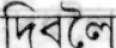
দিবলৈ
